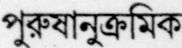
পুরুষানুক্রমিক
